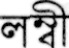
লম্বী
